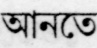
আনতে
